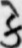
કે
